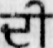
ਦੀ
